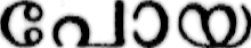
പോയ
